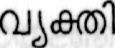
വ്യക്തി
